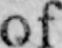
of
